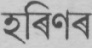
হৰিণৰ
